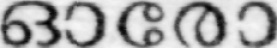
ഓരോ
